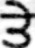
ਤੇ
